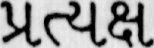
પ્રત્યક્ષ
